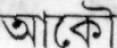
আকৌ
